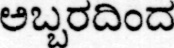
ಅಬ್ಬರದಿಂದ
